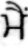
ਮੈਂ
